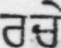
ਰਚੇ
